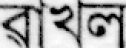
ৱাখল
